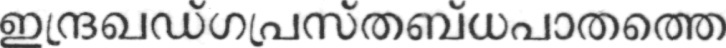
ഇന്ദ്രഖഡ്ഗപ്രസ്തബ്ധപാതത്തെ
